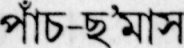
পাঁচ-ছ'মাস
